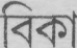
বিকা
